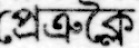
প্রেত্রুক্লৈ
